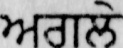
ਅਗਲੇ
